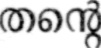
തന്റെ
